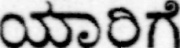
ಯಾರಿಗೆ
